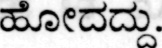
ಹೋದದ್ದು.
